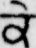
ਕੇ
